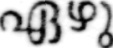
ഏഴു
